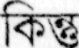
কিন্তু
